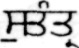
ਸੁਤੰਤ੍ਰ
